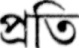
প্রতি
